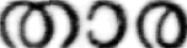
താര
